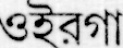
ওইরগা
